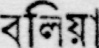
বলিয়া
